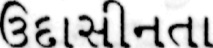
ઉદાસીનતા
